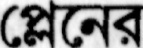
প্লেনের
